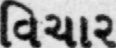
વિચાર
